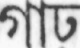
গাঢ়
